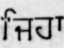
ਜਿਹਾ
